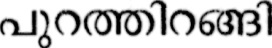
പുറത്തിറങ്ങി
